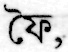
ফৈ,
